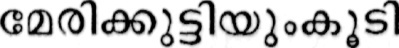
മേരിക്കുട്ടിയുംകൂടി
